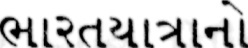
ભારતયાત્રાનો
